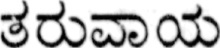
ತರುವಾಯ
